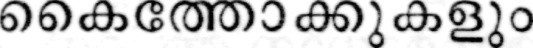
കൈത്തോക്കുകളും
